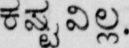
ಕಷ್ಟವಿಲ್ಲ.
